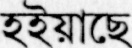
হইয়াছে
